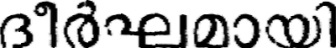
ദീര്‍ഘമായി
